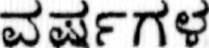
ವರ್ಷಗಳ
